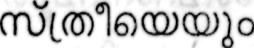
സ്ത്രീയെയും
